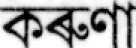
কৰুণা
